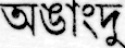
অঙাংদু
